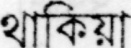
থাকিয়া
